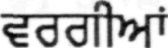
ਵਰਗੀਆਂ
